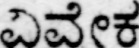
ವಿವೇಕ
